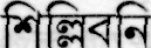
শিল্লিবনি
